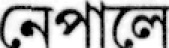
নেপালে
